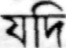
যদি
